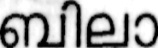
ബിലാ
